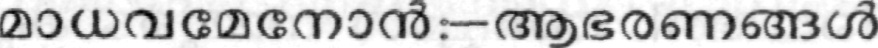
മാധവമേനോന്‍:-ആഭരണങ്ങള്‍
